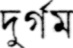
দুর্গম
